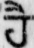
ਹੈ
